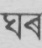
ঘৰ
